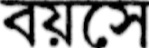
বয়সে
